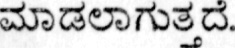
ಮಾಡಲಾಗುತ್ತದೆ.
